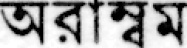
অরাম্বম
